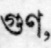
গুণ,
